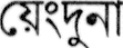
য়েংদুনা
